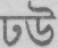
ঢউ
